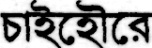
চাইহৌরে
